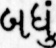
બધું
